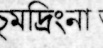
চুমদ্রিংনা
